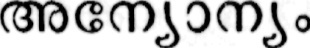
അന്യോന്യം
